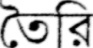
তৈরি
